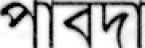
পাবদা
